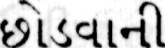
છોડવાની
